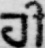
ਹੀ
